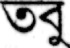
তবু
